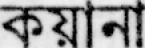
কয়ানা
